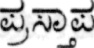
ಪ್ರಸ್ತಾಪ
